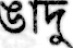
ঙাদু
